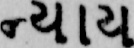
ન્યાય
